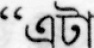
"এটা
